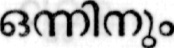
ഒന്നിനും
